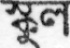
স্কুল
